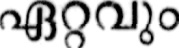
ഏറ്റവും
